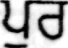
ਪੁਰ
